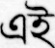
এই
